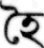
হৈ
